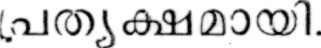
പ്രത്യക്ഷമായി.
